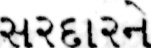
સરદારને
